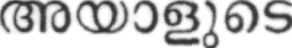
അയാളുടെ
